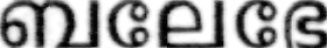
ബലേഭേ
